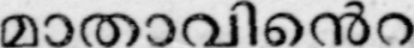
മാതാവിന്റെ
